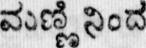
ಮಣ್ಣಿನಿಂದ
